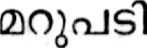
മറുപടി
